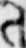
તે
